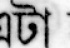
এটা
